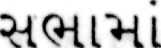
સભામાં
